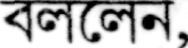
বললেন,
